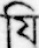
যি
